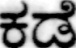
ಕಡೆ
